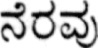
ನೆರವು
